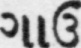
ગાઉ
